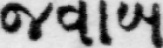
જવાબ
